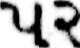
પર
